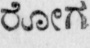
ರೋಗ
